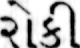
રોકી
